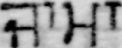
ਜਾਮਾ
